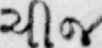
ચીજ
